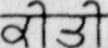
ਕੀਤੀ
